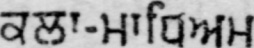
ਕਲਾ-ਮਾਧਿਅਮ
